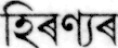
হিৰণ্যৰ
